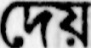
দেয়
